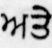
ਅਤੇ
